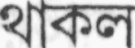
থাকল
